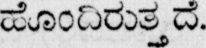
ಹೊಂದಿರುತ್ತದೆ.
